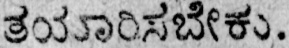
ತಯಾರಿಸಬೇಕು.
